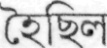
হৈছিল
